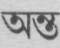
অন্ত
